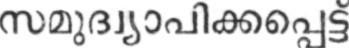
സമുദ്വ്യാപിക്കപ്പെട്ട്
